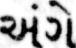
અંગે
